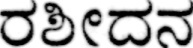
ರಶೀದನ
